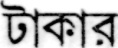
টাকার
